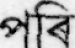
পৰি
